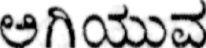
ಅಗಿಯುವ
